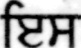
ਇਸ
